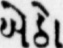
બેઠો
